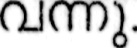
വന്നു.
